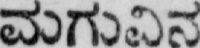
ಮಗುವಿನ
